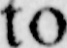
to
